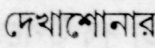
দেখাশোনার
